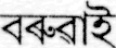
বৰুৱাই
